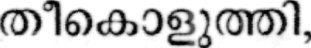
തീകൊളുത്തി,
